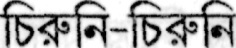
চিরুনি-চিরুনি
